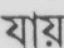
যায়
